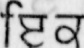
ਇਕ
